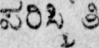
ಪರಿಸ್ಥಿತಿ
